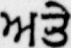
ਅਤੇ
